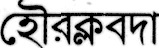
হৌরক্লবদা
